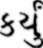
કર્યું
